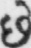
છે
